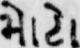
મોટો
